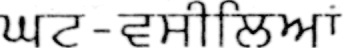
ਘਟ-ਵਸੀਲਿਆਂ
